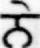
ਨੇ
